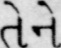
તેને
